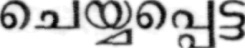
ചെയ്യപ്പെട്ട
